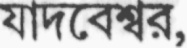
যাদবেশ্বর,
